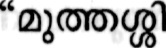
“മുത്തശ്ശി
